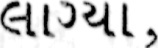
લાગ્યા,
